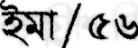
ইমা/৫৬
